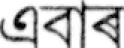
এবাৰ
